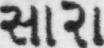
સારા
